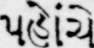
પહોંચે
